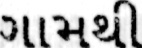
ગામથી
